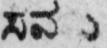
ಸಮು
